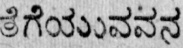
ತೆಗೆಯುವವನ
